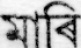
মাৰি
